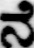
ನೆ
